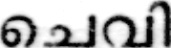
ചെവി
